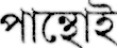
পান্থোই
